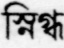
স্নিগ্ধ
